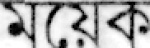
ময়েক
